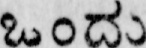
ಒಂದು
